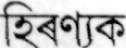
হিৰণ্যক
